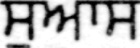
ਸੁਆਸ
